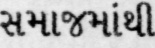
સમાજમાંથી
